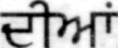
ਦੀਆਂ
